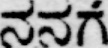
ನನಗೆ
